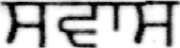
ਸਵਾਸ
